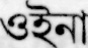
ওইনা
